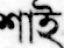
শাই
